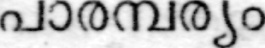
പാരമ്പര്യം
